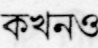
কখনও
